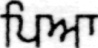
ਪਿਆ
